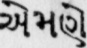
એમણે
